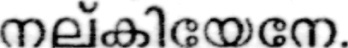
നല്കിയേനേ.
